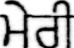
ਮੇਰੀ
